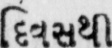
દિવસથી
